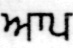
ਆਪ
